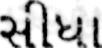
સીધા
